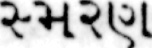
સ્મરણ
